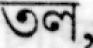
তল,
